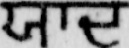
ਯਾਦ
